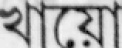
খায়ো
